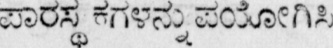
ಪಾರಸ್ಥಕಗಳನ್ನುಪಯೋಗಿಸಿ
